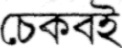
চেকবই
